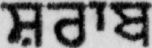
ਸ਼ਰਾਬ
